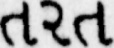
તરત
